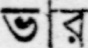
ভার
